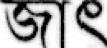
জাৎ
